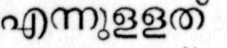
എന്നുള്ളത്
